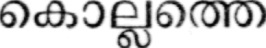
കൊല്ലത്തെ
